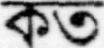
কত
